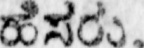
ಹೆಸರು.
